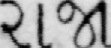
રાજા
